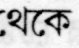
থেকে
